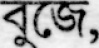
বুজে,
